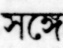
সঙ্গে
